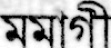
মমাগী
